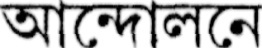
আন্দোলনে
